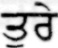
ਤੁਰੇ
